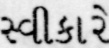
સ્વીકારે
